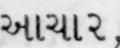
આચાર,
